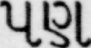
પણ
